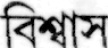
বিশ্বাস
